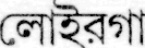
লোইরগা
